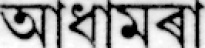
আধামৰা
